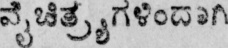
ವೈಚಿತ್ರ್ಯಗಳಿ೦ದಾಗಿ
